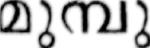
മുമ്പു
